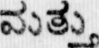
ಮತ್ತು
